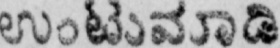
ಉಂಟುಮಾಡಿ
